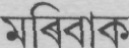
মৰিবাক
